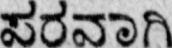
ಪರವಾಗಿ
